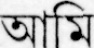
আমি
